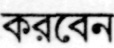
করবেন
